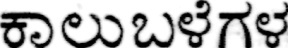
ಕಾಲುಬಳೆಗಳ
